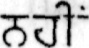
ਨਹੀਂ
